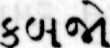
કબજો
